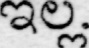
ಇಲ್ಲ.
